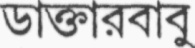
ডাক্তারবাবু
